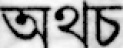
অথচ
